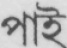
পাই
